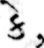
કે,
